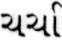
ચર્ચા
